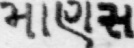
માણસ
